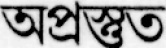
অপ্রস্তুত
